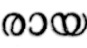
രായ
